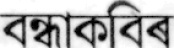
বন্ধাকবিৰ
